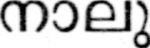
നാലു
